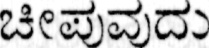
ಚೀಪುವುದು
